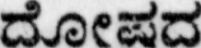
ದೋಷದ
